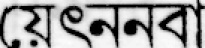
য়েৎননবা
